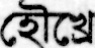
হৌখ্রে
